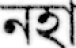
নহা
